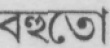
বহুতো
